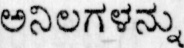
ಅನಿಲಗಳನ್ನು
